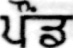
ਪੌਂਡ
